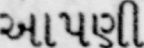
આપણી
